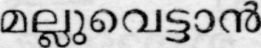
മല്ലുവെട്ടാന്‍
